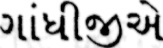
ગાંધીજીએ
